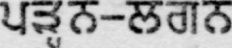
ਪੜ੍ਹਨ-ਲਗਨ
